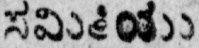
ಸಮಿತಿಯು
